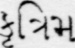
કુત્રિમ
